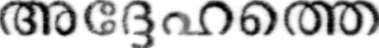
അദ്ദേഹത്തെ
